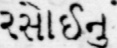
રસોઈનું
